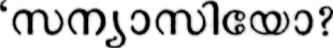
'സന്യാസിയോ?
